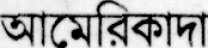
আমেরিকাদা
